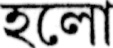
হলো
